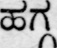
ಹಗ್ಗ
